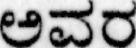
ಅವರ
